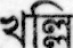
খল্লি
